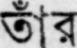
তাঁর
